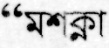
“মশক্না
